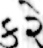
કરે
